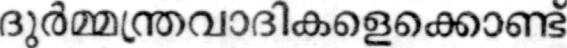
ദുര്‍മ്മന്ത്രവാദികളെക്കൊണ്ട്
